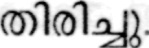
തിരിച്ചു.
